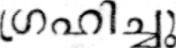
ഗ്രഹിച്ചു
